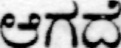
ಆಗದೆ
